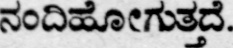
ನಂದಿಹೋಗುತ್ತದೆ.
